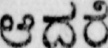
ಆದರೆ
